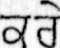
ਕਰੇ
